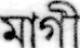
মাগী
